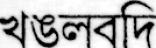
খঙলবদি
